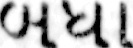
બધા
